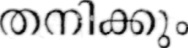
തനിക്കും
